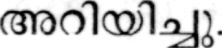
അറിയിച്ചു.
